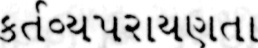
કર્તવ્યપરાયણતા
